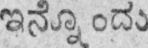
ಇನ್ನೊಂದು
